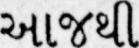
આજથી
